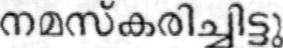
നമസ്കരിച്ചിട്ടു
